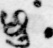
છું.
